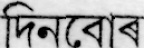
দিনবোৰ
